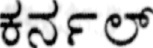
ಕರ್ನಲ್
